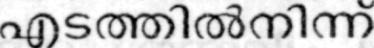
എടത്തില്‍നിന്ന്
